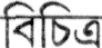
বিচিত্র
